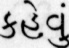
કહેવું
